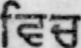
ਵਿਚ
